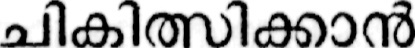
ചികിത്സിക്കാന്‍
